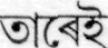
তাৰেই
